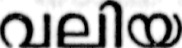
വലിയ
